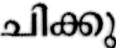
ചിക്കു
